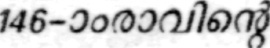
146-ാംരാവിന്റെ
